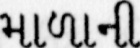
માળાની
